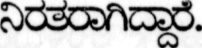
ನಿರತರಾಗಿದ್ದಾರೆ.
